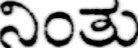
ನಿಂತು
